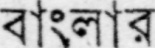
বাংলার
